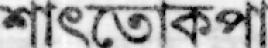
শাৎতোকপা
